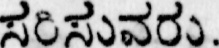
ಸರಿಸುವರು.
